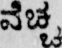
ವೆಚ್ಚ
